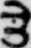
ਤੇ
